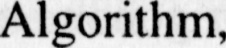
Algorithm,
